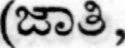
(ಜಾತಿ,
